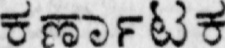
ಕರ್ಣಾಟಕ
